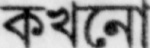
কখনো
